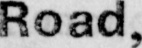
Road,
